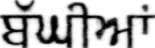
ਬੱਘੀਆਂ
